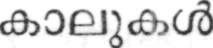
കാലുകള്‍
